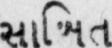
સાબિત
